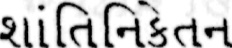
શાંતિનિકેતન
